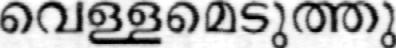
വെള്ളമെടുത്തു
